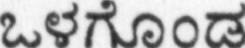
ಒಳಗೊಂಡ
